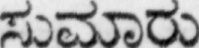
ಸುಮಾರು
